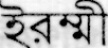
ইরম্মী
